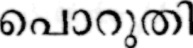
പൊറുതി
